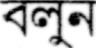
বলুন
